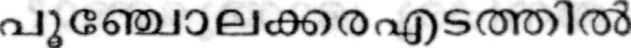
പൂഞ്ചോലക്കരഎടത്തില്‍
